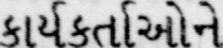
કાર્યકર્તાઓને
